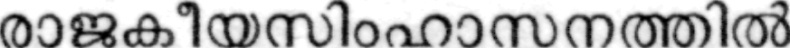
രാജകീയസിംഹാസനത്തില്‍
